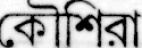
কৌশিরা
